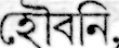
হৌবনি,
